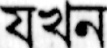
যখন
